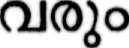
വരും
